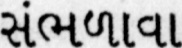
સંભળાવા
